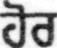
ਹੋਰ
